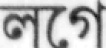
লগে
